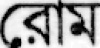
রোম
